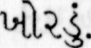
ખોરડું.
